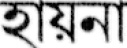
হায়না
